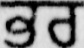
ਭਰ
